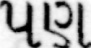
પણ
